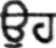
ਉਹ
